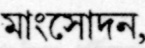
মাংসোদন,
